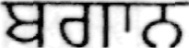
ਬਗਾਨ
